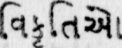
વિકૃતિઓ
